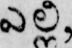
ಎಲ್ಲಿ,
